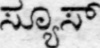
ಸ್ಯೂಸ್
